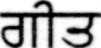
ਗੀਤ
